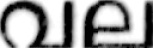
വല
